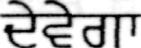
ਦੇਵੇਗਾ
